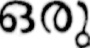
ഒരു
